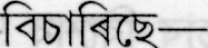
বিচাৰিছে-
